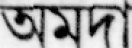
অমদা
